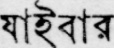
যাইবার
